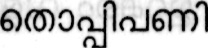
തൊപ്പിപണി
